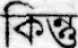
কিন্তু
